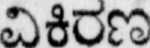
ವಿಕಿರಣ
